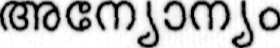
അന്യോന്യം
